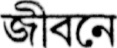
জীবনে
